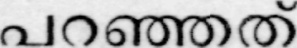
പറഞ്ഞത്
